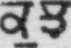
ਕੁਝ
